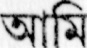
আমি
